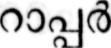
റാപ്പര്‍
